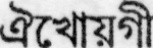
ঐখোয়গী
